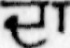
ਦਾ
